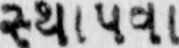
સ્થાપવા
